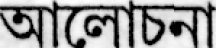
আলোচনা
